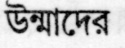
উন্মাদের
